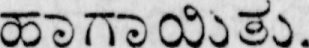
ಹಾಗಾಯಿತು.
